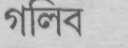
গলিব
